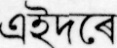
এইদৰে
